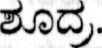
ಶೂದ್ರ.
